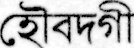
হৌবদগী
